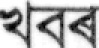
খবৰ
